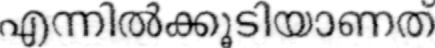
എന്നില്‍ക്കൂടിയാണത്
